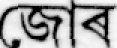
জোৰ
